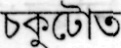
চকুটোত
